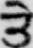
ਤੇ
